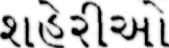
શહેરીઓ
